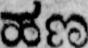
ಹಣ
